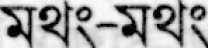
মথং-মথং
